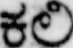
ಕಲಿ
